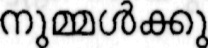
നുമ്മള്‍ക്കു
